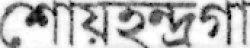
শোয়হন্দ্রগা
